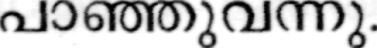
പാഞ്ഞുവന്നു.
